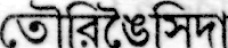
তৌরিঙৈসিদা
